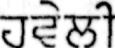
ਹਵੇਲੀ
